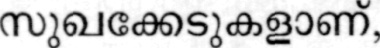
സുഖക്കേടുകളാണ്,
